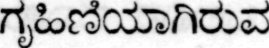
ಗೃಹಿಣಿಯಾಗಿರುವ
